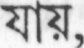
যায়,
